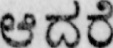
ಆದರೆ
